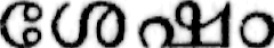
ശേഷം
